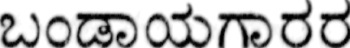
ಬಂಡಾಯಗಾರರ
